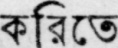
করিতে
